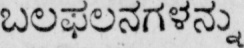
ಬಲಫಲನಗಳನ್ನು
